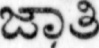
ಜಾತಿ
